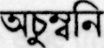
অচুম্বনি
